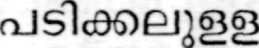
പടിക്കലുള്ള
